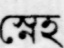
স্নেহ
